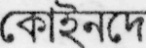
কোইনদে
